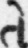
તે
